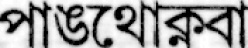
পাঙথোক্নবা
